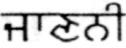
ਜਾਣਨੀ
